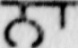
ਨਾ
